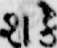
શકે
